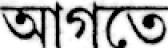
আগতে
